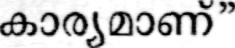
കാര്യമാണ്”
